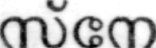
സ്നേ
